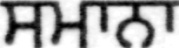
ਸਮਾਨਾ
